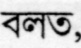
বলত,
